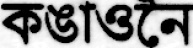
কঙাওনৈ
